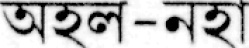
অহল-নহা
